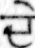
ਦੇ
